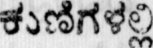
ಕುಣಿಗಳಲ್ಲಿ
